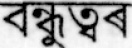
বন্ধুত্বৰ
